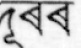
দূৰৰ
